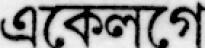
একেলগে
